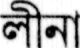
লীনা
